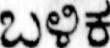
ಬಳಿಕ
